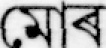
মোৰ
